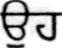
ਉਹ
